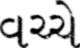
વચ્ચે
